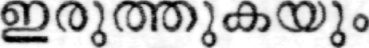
ഇരുത്തുകയും
